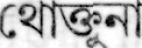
থোক্তুনা
